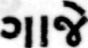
ગાજે
